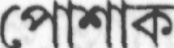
পোশাক
